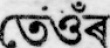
তেওঁৰ
